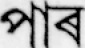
পাৰ
